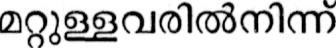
മറ്റുള്ളവരില്‍നിന്ന്
